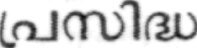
പ്രസിദ്ധ
